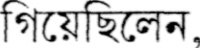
গিয়েছিলেন,
